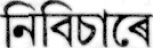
নিবিচাৰে
